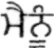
ਮੈਨੂੰ
